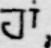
ਹਾਂ,
